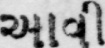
આવી
